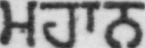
ਮਹਾਨ
